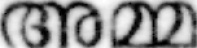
അമ്മ
